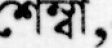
শেম্বা,
